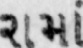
રામાં
